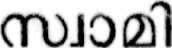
സ്വാമി
